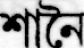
শানৈ
